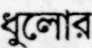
ধুলোর
